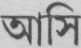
আসি
